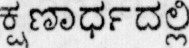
ಕ್ಷಣಾರ್ಧದಲ್ಲಿ
